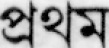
প্রথম
